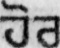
ਹੋਰ
